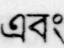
এবং
